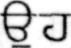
ਉਹ
